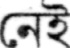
নেই
